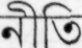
নীতি
